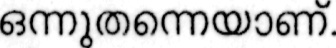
ഒന്നുതന്നെയാണ്.
